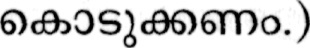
കൊടുക്കണം.)
